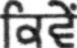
ਕਿਵੇਂ
